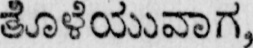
ತೊಳೆಯುವಾಗ,
